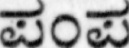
ಪಂಪ
